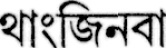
থাংজিনবা
